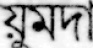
য়ুমদা
